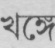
খঙ্গে
